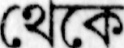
থেকে
